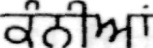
ਕੰਨੀਆਂ
